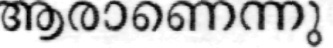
ആരാണെന്നു
